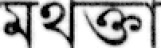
মথক্তা
